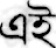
এই
